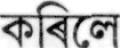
কৰিলে
